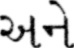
અને
